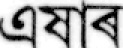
এষাৰ
